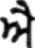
ਐ
